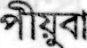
পীয়ুবা
